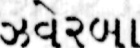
ઝવેરબા
